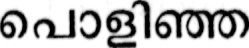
പൊളിഞ്ഞ
